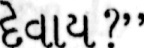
દેવાય?"
